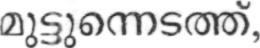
മുട്ടുന്നെടത്ത്,
